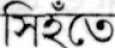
সিহঁতে
